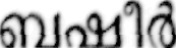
ബഷീര്‍
